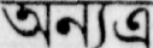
অন্যত্র
